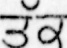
ਤੱਕ
